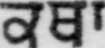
ਕਥਾ
